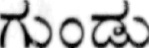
ಗುಂಡು
